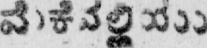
ಮೆಕೆವಲ್ಲಿಯು
